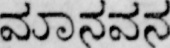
ಮಾನವನ
